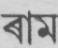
ৰাম
